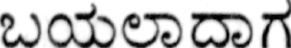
ಬಯಲಾದಾಗ
